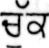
ਚੁੱਕ
